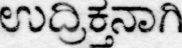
ಉದ್ರಿಕ್ತನಾಗಿ
